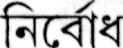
নির্বোধ
